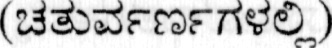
(ಚತುರ್ವರ್ಣಗಳಲ್ಲಿ)
